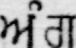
ਅੰਗ
